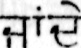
ਜਾਂਦੇ
